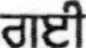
ਗਈ
